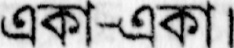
একা-একা।
